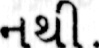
નથી.
